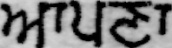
ਆਪਣਾ
